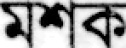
মশক
